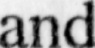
and
